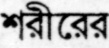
শরীরের
